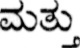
ಮತ್ತು
